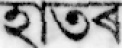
হাতৰ
